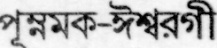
পূম্নমক-ঈশ্বরগী
